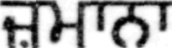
ਜ਼ਮਾਨਾ
